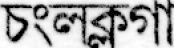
চংলক্লগা
